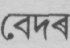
বেদৰ
